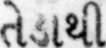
તેડાથી
